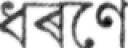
ধৰণে
